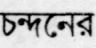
চন্দনের
